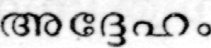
അദ്ദേഹം
